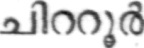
ചിററൂര്‍
